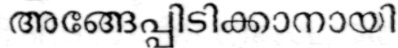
അങ്ങേപ്പിടിക്കാനായി
